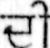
ਦੀ
